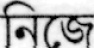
নিজে
